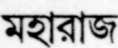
মহারাজ
